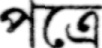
পত্রে
